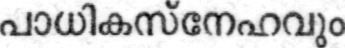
പാധികസ്നേഹവും
